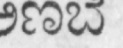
ಅಣಬೆ
